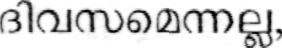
ദിവസമെന്നല്ല,
